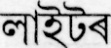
লাইটৰ
